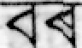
বৰ
